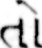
તો
